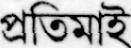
প্রতিমাই
